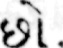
છો.
